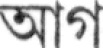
আগ
